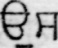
ਉਸ
